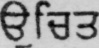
ਉਚਿਤ
